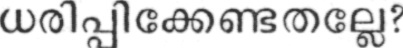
ധരിപ്പിക്കേണ്ടതല്ലേ?
